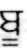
ਬੂ
